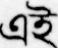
এই
